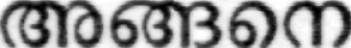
അങ്ങനെ
